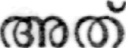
അത്
